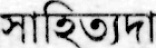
সাহিত্যদা
